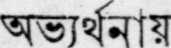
অভ্যর্থনায়
